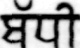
ਬੱਧੀ
